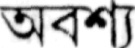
অবশ্য
